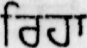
ਰਿਹਾ
